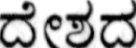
ದೇಶದ
